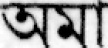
অমা
